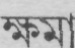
ক্ষমা
